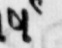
વર્ષ
